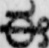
ಈ
